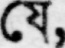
যে,
